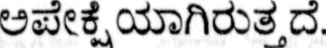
ಅಪೇಕ್ಷೆಯಾಗಿರುತ್ತದೆ.
